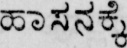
ಹಾಸನಕ್ಕೆ
